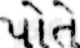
પોતે
